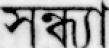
সন্ধ্যা
